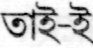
তাই-ই
